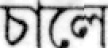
চালে
